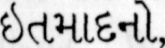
ઇતમાદનો,
